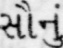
સૌનું
